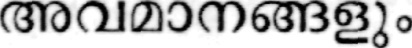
അവമാനങ്ങളും
